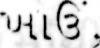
ખાઉં,
